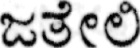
ಜತೇಲಿ
